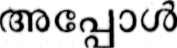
അപ്പോള്‍
